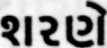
શરણે
